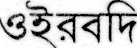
ওইরবদি
